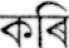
কৰি
